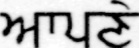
ਆਪਣੇ
